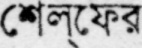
শেল্‌ফের
